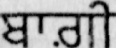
ਬਾਗ਼ੀ
